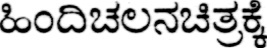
ಹಿಂದಿಚಲನಚಿತ್ರಕ್ಕೆ
